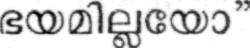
ഭയമില്ലയോ”
